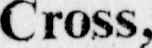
Cross,
